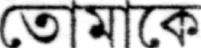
তোমাকে
